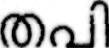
തപി
